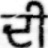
ਦੀ
